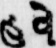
હવે
